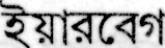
ইয়ারবেগ
